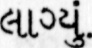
લાગ્યું.
